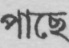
পাছে
